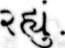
રહ્યું.
